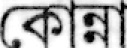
কোন্না
